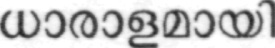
ധാരാളമായി
